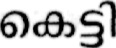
കെട്ടി
